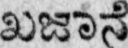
ಖಜಾನೆ
